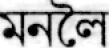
মনলৈ
